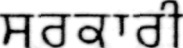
ਸਰਕਾਰੀ
